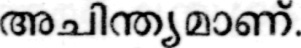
അചിന്ത്യമാണ്.
